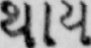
થાય
